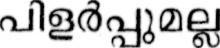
പിളര്‍പ്പുമല്ല
